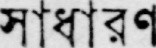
সাধারণ
